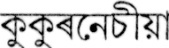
কুকুৰনেচীয়া
